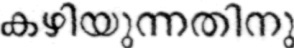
കഴിയുന്നതിനു
